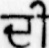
ਦੀ
